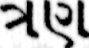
ત્રણ
